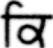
ਕਿ
